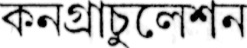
কনগ্রাচুলেশন
